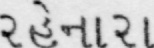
રહેનારા
